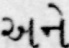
અને
